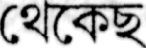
থেকেছ
